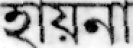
হায়না
